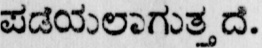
ಪಡೆಯಲಾಗುತ್ತದೆ.
